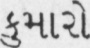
કુમારો
